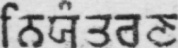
ਨਿਯੰਤਰਣ
